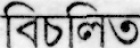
বিচলিত
